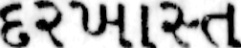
દરખાસ્ત
